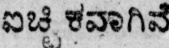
ಐಚ್ಛಿಕವಾಗಿವೆ
